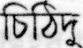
চিঠিদু
